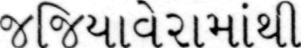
જજિયાવેરામાંથી
